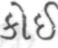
કોઈ
